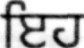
ਇਹ
